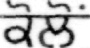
ਕੋਲੋਂ
